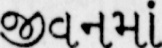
જીવનમાં
